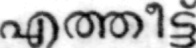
എത്തീട്ട്
